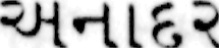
અનાદર
